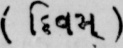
(દિવમ્)
